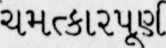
ચમત્કારપૂર્ણ
